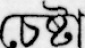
চেষ্টা
